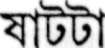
ষাটটা
